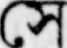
সে
